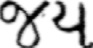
જય
